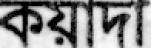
কয়াদা
